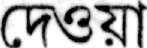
দেওয়া
